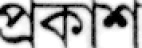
প্রকাশ
